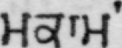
ਮਕਾਮ'
